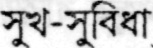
সুখ-সুবিধা
